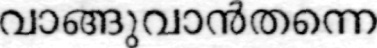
വാങ്ങുവാന്‍തന്നെ
